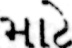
માટે
